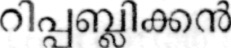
റിപ്പബ്ലിക്കന്‍
